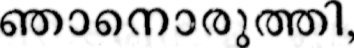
ഞാനൊരുത്തി,
